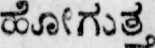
ಹೋಗುತ್ತ
